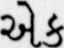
એક
